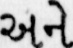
અને
